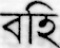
বহি
